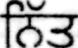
ਨਿੱਤ
